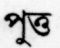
পুত্ত
